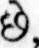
છે,
